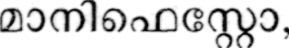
മാനിഫെസ്റ്റോ,
